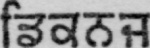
ਡਿਕਨਜ
